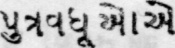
પુત્રવધૂઓએ
